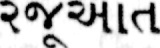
રજૂઆત
